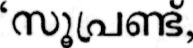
'സൂപ്രണ്ട്,
